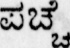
ಪಚ್ಚೆ
